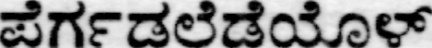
ಪೆರ್ಗಡಲೆಡೆಯೊಳ್
